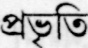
প্রভৃতি
